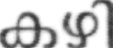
കഴി
